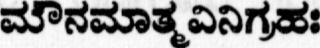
ಮೌನಮಾತ್ಮವಿನಿಗ್ರಹಃ
